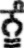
ਨੂੰ
